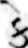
કે
